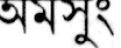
অমসুং
